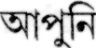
আপুনি
